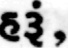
હરૂં,
